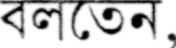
বলতেন,
